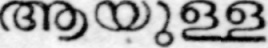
ആയുള്ള
